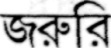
জরুরি
